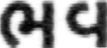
ભવ
